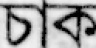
চাক
